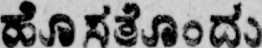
ಹೊಸತೊಂದು
